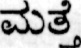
ಮತ್ತೆ
